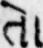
તો
